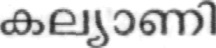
കല്യാണി
